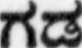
ಗಡ
